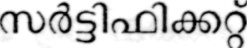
സര്‍ട്ടിഫിക്കറ്റ്
